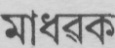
মাধৱক
